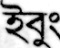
ইবুং
